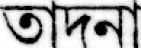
তাদনা
